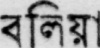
বলিয়া
